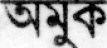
অমুক
